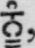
ਨੂੰ,
